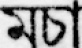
মচা
